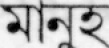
মানুহ
